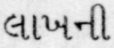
લાખની
